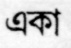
একা
